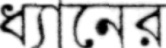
ধ্যানের
